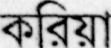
করিয়া
